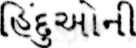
હિંદુઓની
